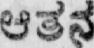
ಆತನ
